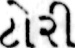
ટોરી
